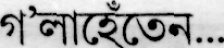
গ'লাহেঁতেন...
